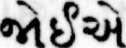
જોઈએ
